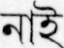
নাই
